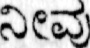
ನೀವು
